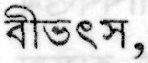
বীভৎস,
